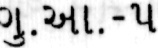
ગુ.આ.-૫
